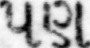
પણ
